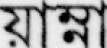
য়াম্না
